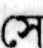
সে
